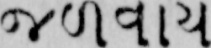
જળવાય
